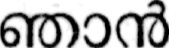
ഞാന്‍
